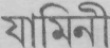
যামিনী
